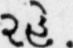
રહે.
